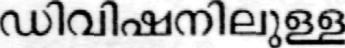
ഡിവിഷനിലുള്ള
